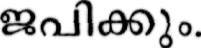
ജപിക്കും.
